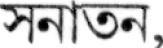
সনাতন,
